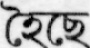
হৈছে
